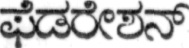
ಫೆಡರೇಶನ್
